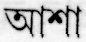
আশা
